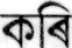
কৰি
